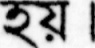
হয়।
